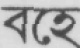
বহে
